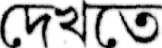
দেখতে
